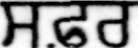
ਸਫ਼ਰ
